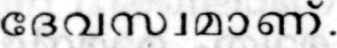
ദേവസ്വമാണ്.
